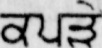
ਕਪੜੇ
